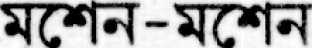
মশেন-মশেন
